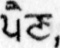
ਪੈਣ,
